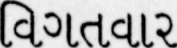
વિગતવાર
